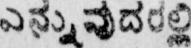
ಎನ್ನುವುದರಲ್ಲಿ
